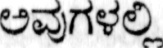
ಅವುಗಳಲ್ಲಿ
